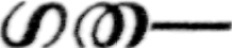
ഗത-
